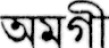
অমগী
